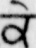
ਕੇ
